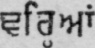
ਵਰ੍ਹਿਆਂ
